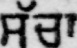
ਸੱਚਾ
